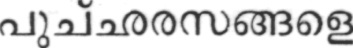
പുച്ഛരസങ്ങളെ
